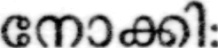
നോക്കി:
